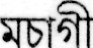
মচাগী
